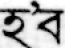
হ'ব
